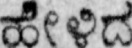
ಹೇಳಿದ
